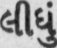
લીધું
